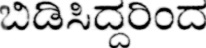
ಬಿಡಿಸಿದ್ದರಿಂದ
